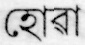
হোৱা
